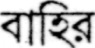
বাহির
